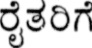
ರೈತರಿಗೆ
